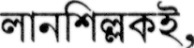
লানশিল্লকই,
